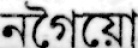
নগৈয়ো
